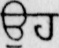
ਉਹ
